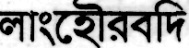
লাংহৌরবদি
